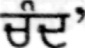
ਚੰਦ'
